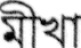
মীখা
